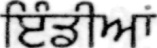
ਇੰਡੀਆਂ
